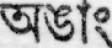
অঙাং
